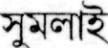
সুমলাই
